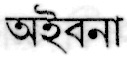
অইবনা
